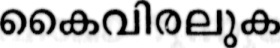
കൈവിരലുക
